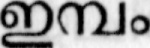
ഇമ്പം
